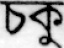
চকু
